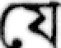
যে
